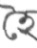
হৈ
